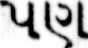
પણ
